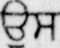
ਉਸ
